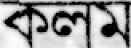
কলম
